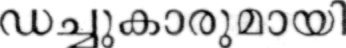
ഡച്ചുകാരുമായി
